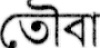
তৌবা
